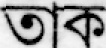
তাক
